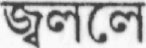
জ্বললে
